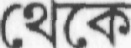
থেকে
